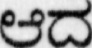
ಆದ
